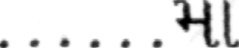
......મા
